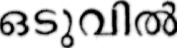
ഒടുവില്‍
